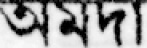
অমদা
